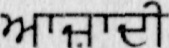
ਆਜ਼ਾਦੀ
